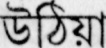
উঠিয়া
